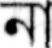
না
